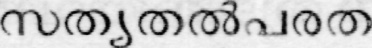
സത്യതല്‍പരത
